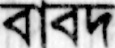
বাবদ
